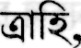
ত্রাহি,
